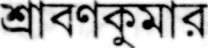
শ্রাবণকুমার
